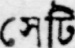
সেটি
